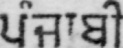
ਪੰਜਾਬੀ
